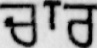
ਚਾਰ
